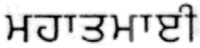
ਮਹਾਤਮਾਈ
